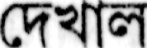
দেখাল
